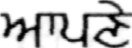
ਆਪਣੇ
